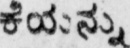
ಕೆಯನ್ನು
